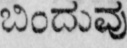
ಬಿಂದುವು
